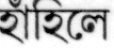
হাঁহিলে
